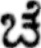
ಚೆ
